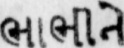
ભાભીને
